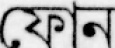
ফোন
